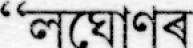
"লঘোণৰ
